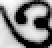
ও
